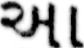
આ
